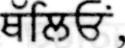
ਥੱਲਿਓਂ,
